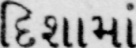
દિશામાં
